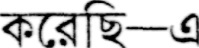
করেছি–এ
